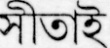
সীতাই
